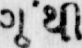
ગૂંથી
